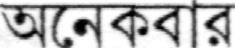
অনেকবার
